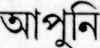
আপুনি
